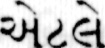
એટલે
